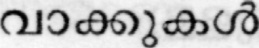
വാക്കുകള്‍
